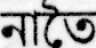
নাতৈ
